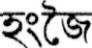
হংজৈ
